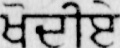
ਖੋਦੀਏ
